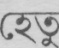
হেতু
